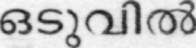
ഒടുവില്‍
